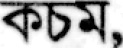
কচম,
